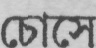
চোসে
